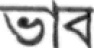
ভাব
